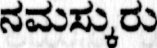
ನಮಸ್ಕುರು
